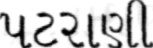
પટરાણી
